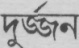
দুৰ্জ্জন
